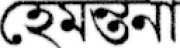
হেমন্তনা
